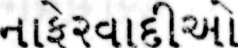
નાફેરવાદીઓ
